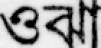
ওঝা
